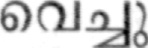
വെച്ചു
